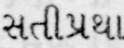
સતીપ્રથા
